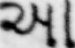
આ
